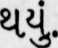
થયું.
